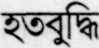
হতবুদ্ধি
